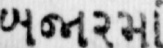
બજારમાં
